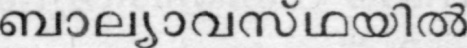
ബാല്യാവസ്ഥയില്‍
